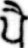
ਪੈ
